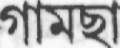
গামছা
